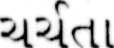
ચર્ચતા
